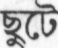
ছুটে
